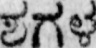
ಶಗಳ
